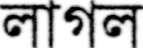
লাগল
